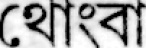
থোংবা
